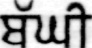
ਬੱਘੀ
